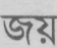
জয়
